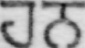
ਹਨ
